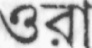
ওরা
